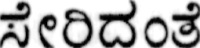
ಸೇರಿದಂತೆ
